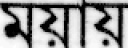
ময়ায়
